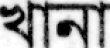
খানা
